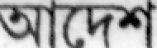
আদেশ
